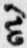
દે
